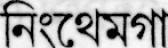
নিংথেমগা
